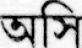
অসি
